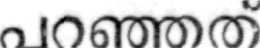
പറഞ്ഞത്
